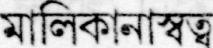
মালিকানাস্বত্ব
